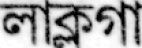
লাক্লগা
